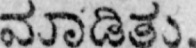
ಮಾಡಿತು.
